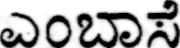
ಎಂಬಾಸೆ
